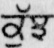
ਕੁੱਝ
